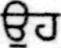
ਉਹ
